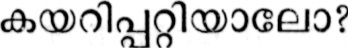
കയറിപ്പറ്റിയാലോ?
